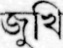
জুখি
